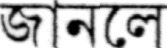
জানলে
